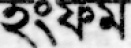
হংফম
